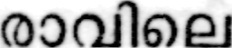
രാവിലെ
